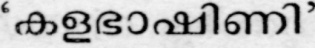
'കളഭാഷിണി'
